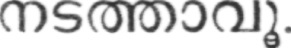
നടത്താവൂ.
